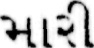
મારી
